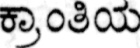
ಕ್ರಾಂತಿಯ
